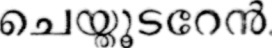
ചെയ്തൂടറേന്‍.
